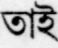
তাই
